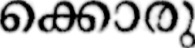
ക്കൊരു
